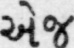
એજ
